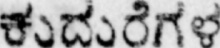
ಕುದುರೆಗಳ
